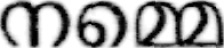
നമ്മെ
